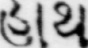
હાથ
